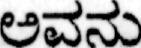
ಅವನು
